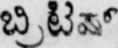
ಬ್ರಿಟಿಷ್
